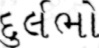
દુર્લભો
